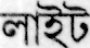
লাইট
